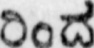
ರಿಂದ
